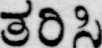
ತರಿಸಿ
